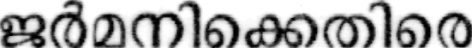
ജര്‍മനിക്കെതിരെ
